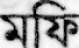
মফি
